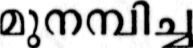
മുനമ്പിച്ച
